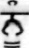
ਨੂੰ
